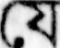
যে
